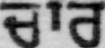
ਚਾਰ
